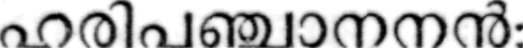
ഹരിപഞ്ചാനനന്‍:
